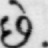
છે.
